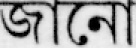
জানো
